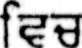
ਵਿਚ
